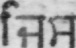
ਜਿਸ
